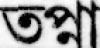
তপ্না
